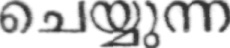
ചെയ്യുന്ന
